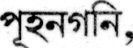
পূহনগনি,
